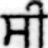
ਸੀ
